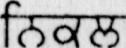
ਨਿਕਲ
